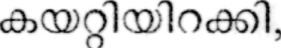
കയറ്റിയിറക്കി,
